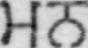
ਮਨ
